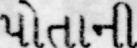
પોતાની
